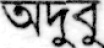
অদুবু
